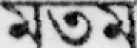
মতম
